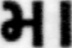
મા
